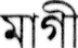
মাগী
